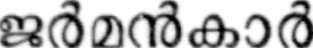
ജര്‍മന്‍കാര്‍
